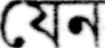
যেন
